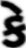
કે
